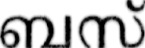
ബസ്
